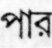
পার
